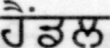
ਹੈਂਡਲ
